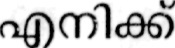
എനിക്ക്
